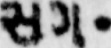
સગ-
